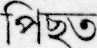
পিছত
